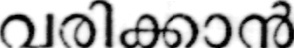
വരിക്കാന്‍
